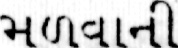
મળવાની
